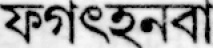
ফগৎহনবা
